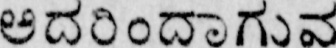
ಅದರಿಂದಾಗುವ
